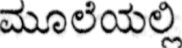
ಮೂಲೆಯಲ್ಲಿ
